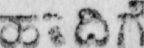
ಹಾದಿಗೆ
